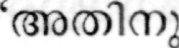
'അതിനു
